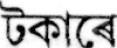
টকাৰে
